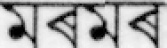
মৰমৰ
